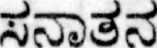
ಸನಾತನ
